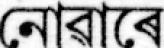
নোৱাৰে
